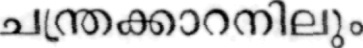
ചന്ത്രക്കാറനിലും
